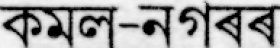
কমল-নগৰৰ
